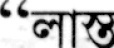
“লাস্ত
